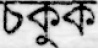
চকুক
